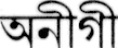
অনীগী
